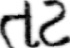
તટ
